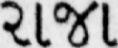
રાજા
